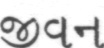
જીવન
